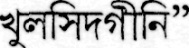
খুলসিদগীনি”
